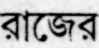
রাজের
